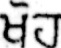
ਖੋਹ
